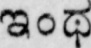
ಇಂಥ
